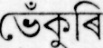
ভেঁকুৰি
